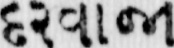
દરવાજા
